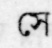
সে
